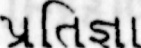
પ્રતિજ્ઞા
